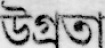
উগ্ৰতা
